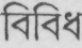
বিবিধ
